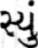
સ્યું
